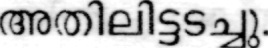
അതിലിട്ടടച്ചു.
